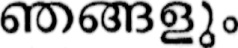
ഞങ്ങളും
